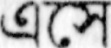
এসে
